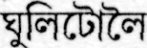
ঘুলিটোলৈ
